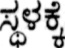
ಸ್ಥಳಕ್ಕೆ
